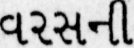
વરસની
